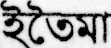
ইতৈমা
